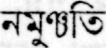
নমুঞ্চতি
